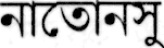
নাতোনসু
